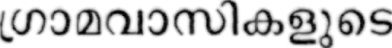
ഗ്രാമവാസികളുടെ
